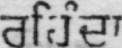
ਰਹਿੰਦਾ
